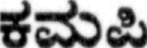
ಕಮಪಿ
